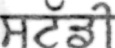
ਸਟੱਡੀ
